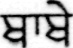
ਬਾਬੇ
